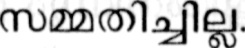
സമ്മതിച്ചില്ല.
